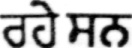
ਰਹੇਸਨ
